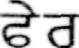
ਫੇਰ
